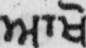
ਆਖੋ
